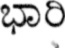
ಭಾರಿ
